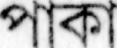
পাকা
